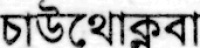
চাউথোক্নবা
